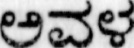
ಅವಳ
